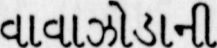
વાવાઝોડાની
